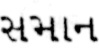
સમાન
